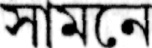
সামনে
